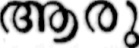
ആരു
